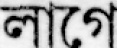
লাগে
